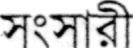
সংসারী
